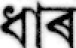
ধাৰ
